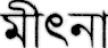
মীৎনা
